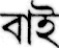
বাই
